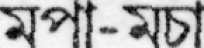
মপা-মচা
